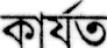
কার্যত
